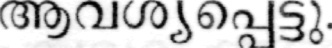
ആവശ്യപ്പെട്ടു.
